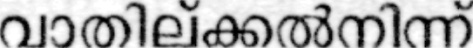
വാതില്ക്കല്‍നിന്ന്
